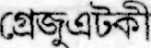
গ্রেজুএটকী
